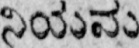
ನಿಯಮ
